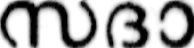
സദാ
